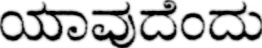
ಯಾವುದೆಂದು
